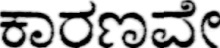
ಕಾರಣವೇ
